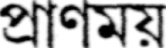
প্রাণময়
